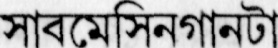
সাবমেসিনগানটা
